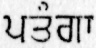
ਪਤੰਗਾ
